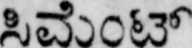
ಸಿಮೆಂಟ್
